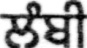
ਲੰਬੀ
